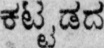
ಕಟ್ಟಡದ
